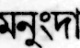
মনুংদা
